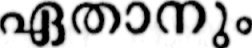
ഏതാനും
